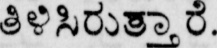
ತಿಳಿಸಿರುತ್ತಾರೆ.
